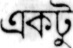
একটু
